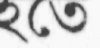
হতে
